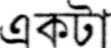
একটা
